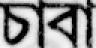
চাবা
